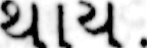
થાય.
